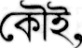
কৌই,
